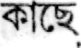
কাছে
